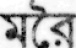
মরৈ
